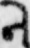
ને
